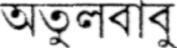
অতুলবাবু
